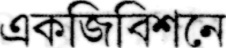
একজিবিশনে
